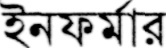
ইনফর্মার
